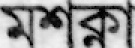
মশক্না
